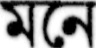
মনে
